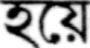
হয়ে
